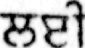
ਲਈ
